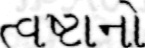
ત્વષ્ટાનો
